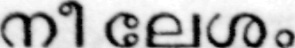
നീലേശം
